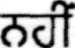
ਨਹੀਂ
